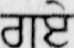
ਗਏ
